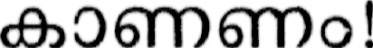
കാണണം!
